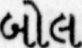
બોલ
